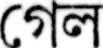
গেল
